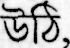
উঠি,
